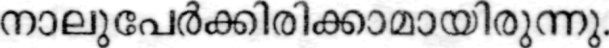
നാലുപേര്‍ക്കിരിക്കാമായിരുന്നു.
